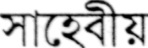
সাহেবীয়
